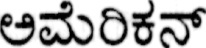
ಅಮೆರಿಕನ್
